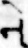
ને
